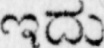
ಇದು
